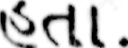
હતા.
